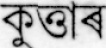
কুত্তাৰ
